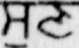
ਸੁਣ
